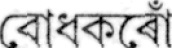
বোধকৰোঁ
